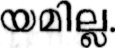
യമില്ല.
